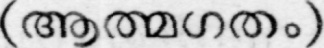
(ആത്മഗതം)
